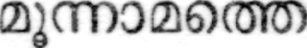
മൂന്നാമത്തെ
